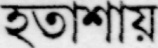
হতাশায়
